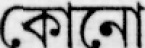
কোনো
